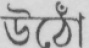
উঠোঁ
